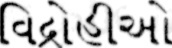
વિદ્રોહીઓ
